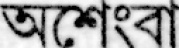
অশেংবা
